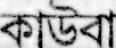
কাউবা
